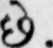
છે.
